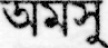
অমসু
